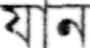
যান
